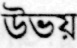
উভয়
